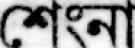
শেংনা
